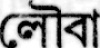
লৌবা
